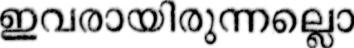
ഇവരായിരുന്നല്ലൊ
